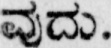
ವುದು.
